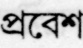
প্রবেশ
